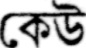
কেউ
